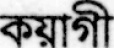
কয়াগী
